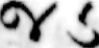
જડ
